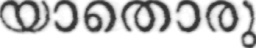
യാതൊരു
